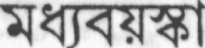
মধ্যবয়স্কা
